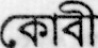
কোবী
